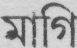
মাগি
